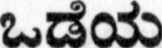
ಒಡೆಯ
